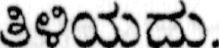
ತಿಳಿಯದು.
